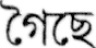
গৈছে
